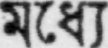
মধ্যে
